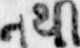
નથી
